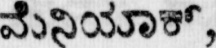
ಮೆನಿಯಾಕ್,
